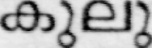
കുലു
